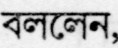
বললেন,
